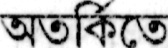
অতর্কিতে
